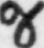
જ
